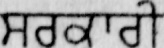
ਸਰਕਾਰੀ
